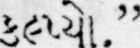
કલ્પ્યો.”
